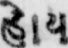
હોય
